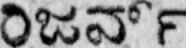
ರಿಜರ್ವ್
